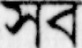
সব
